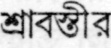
শ্রাবস্তীর
